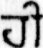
ਹੀ
